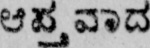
ಆಪ್ತವಾದ
